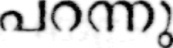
പറന്നു
